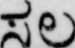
ಸಲ
